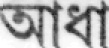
আধা
